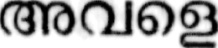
അവളെ
